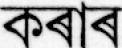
কৰাৰ
